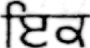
ਇਕ
